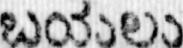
ಬಯಲು
